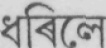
ধৰিলে
